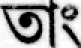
তাং
